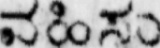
ವಹಿಸು
